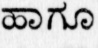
ಹಾಗೂ
